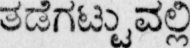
ತಡೆಗಟ್ಟುವಲ್ಲಿ
